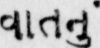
વાતનું
